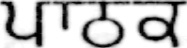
ਪਾਠਕ
